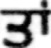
ਤਾਂ
